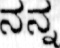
ನನ್ನ
